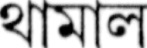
থামাল
